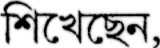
শিখেছেন,
